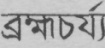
ব্ৰহ্মচৰ্য্য
